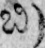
ಬಿ)
